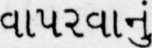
વાપરવાનું
